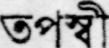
তপস্বী
